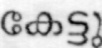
കേട്ടു
